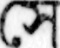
সে
